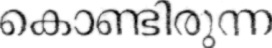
കൊണ്ടിരുന്ന
